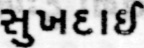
સુખદાઈ
